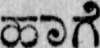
ಹಾಗೆ
